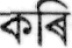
কৰি
